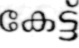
കേട്ട്
